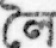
লৈ
